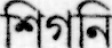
শিগনি
